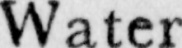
Water
